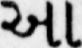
આ
